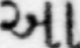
આ
